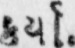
કર્યો.
